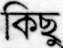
কিছু
